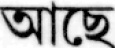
আছে
